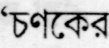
‘চণকের
